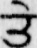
ਤੇ
